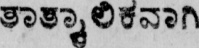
ತಾತ್ಕಾಲಿಕವಾಗಿ
